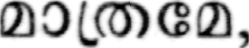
മാത്രമേ,
